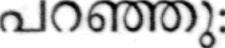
പറഞ്ഞു:
